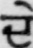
ਦੇ
